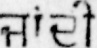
ਜਾਂਦੀ
